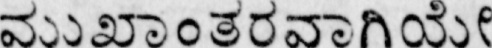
ಮುಖಾಂತರವಾಗಿಯೇ
